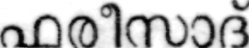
ഫരീസാദ്
